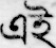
এই
